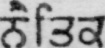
ਨੈਤਿਕ
